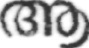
ആ
